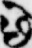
છે
